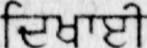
ਦਿਖਾਈ
